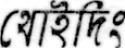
থোইদিং
